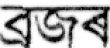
ব্রজৰ
